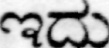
ಇದು
